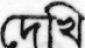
দেখি
